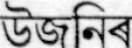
উজনিৰ
